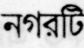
নগরটি
